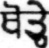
ਥੋੜ੍ਹੇ
